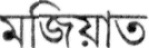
মজিয়াত
